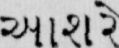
આશરે
